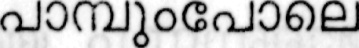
പാമ്പുംപോലെ
